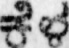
ಕೆಳ
